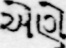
એણે
